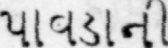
પાવડાની
